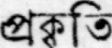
প্রকৃতি
